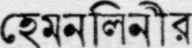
হেমনলিনীর
